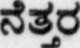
ನೆತ್ತರ
